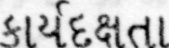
કાર્યદક્ષતા
